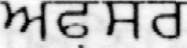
ਅਫ਼ਸਰ
